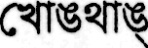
খোঙথাঙ্
